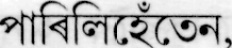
পাৰিলিহেঁতেন,
